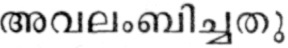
അവലംബിച്ചതു
